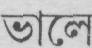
ভালে
